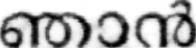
ഞാന്‍
